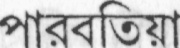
পারবতিয়া
